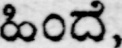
ಹಿಂದೆ,
